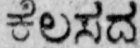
ಕೆಲಸದ
